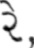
રે,
